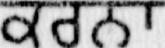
ਕਰਨਾ
